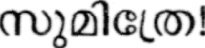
സുമിത്രേ!
